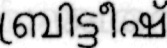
ബ്രിട്ടീഷ്
